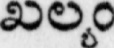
ಖಲ್ಯಂ
